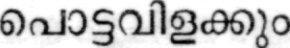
പൊട്ടവിളക്കും
